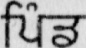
ਪਿੰਡ
